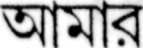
আমার
